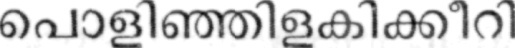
പൊളിഞ്ഞിളകിക്കീറി
